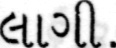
લાગી.
